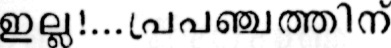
ഇല്ല!...പ്രപഞ്ചത്തിന്
